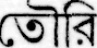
তৌরি
